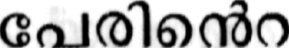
പേരിന്റെ
